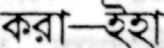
করা—ইহা
